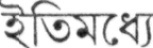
ইতিমধ্যে
